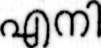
എനി
